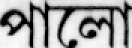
পালো
